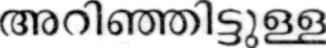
അറിഞ്ഞിട്ടുള്ള
